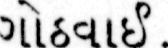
ગોઠવાઈ.
